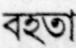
বহতা
